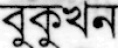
বুকুখন
